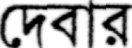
দেবার
